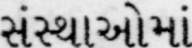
સંસ્થાઓમાં
